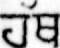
ਹੱਥ
